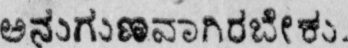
ಅನುಗುಣವಾಗಿರಬೇಕು.
